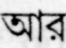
আর
